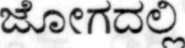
ಜೋಗದಲ್ಲಿ
